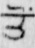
ਤੋਂ
